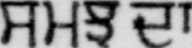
ਸਮਝਦਾ
